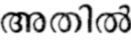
അതില്‍
